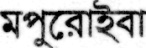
মপুরোইবা
